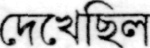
দেখেছিল
